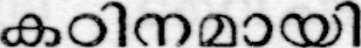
കഠിനമായി
